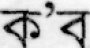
ক'ব
